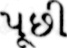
પૂછી
